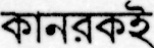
কানরকই
